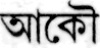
আকৌ
